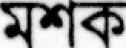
মশক
